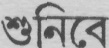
শুনিবে
